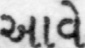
આવે
